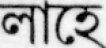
লাহে
